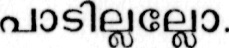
പാടില്ലല്ലോ.
